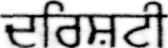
ਦਰਿਸ਼ਟੀ
